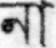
না
